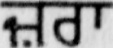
ਜ਼ਰਾ
